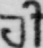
ਹੀ
